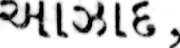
આઝાદ,
